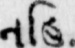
નહિ.
